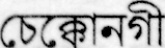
চেক্কোনগী
